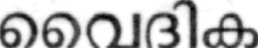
വൈദിക
